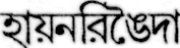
হায়নরিঙৈদা
